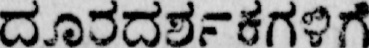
ದೂರದರ್ಶಕಗಳಿಗೆ
